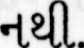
નથી.
